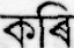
কৰি
